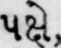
પક્ષે,
